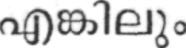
എങ്കിലും
